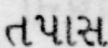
તપાસ
